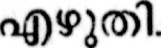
എഴുതി.
